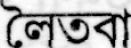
লৈতবা
